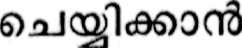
ചെയ്യിക്കാന്‍
